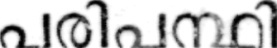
പരിപന്ഥി
